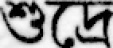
শুদ্রে
